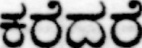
ಕರೆದರೆ
